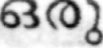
ഒരു
